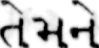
તેમને
